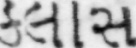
કલાસ
